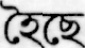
হৈছে
